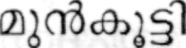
മുന്‍കൂട്ടി
